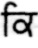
ਕਿ
